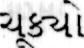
ચૂક્યો
